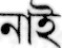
নাই
